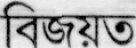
বিজয়ত
